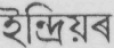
ইন্দ্রিয়ৰ
